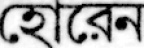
হোরেন
